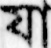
যা
